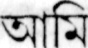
আমি
